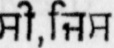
ਸੀ,ਜਿਸ
